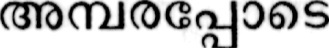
അമ്പരപ്പോടെ
